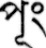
পূং
